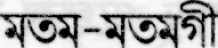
মতম-মতমগী
